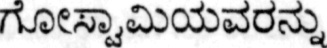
ಗೋಸ್ವಾಮಿಯವರನ್ನು
